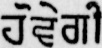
ਹੋਵੇਗੀ
